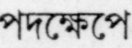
পদক্ষেপে
